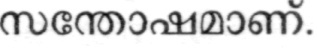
സന്തോഷമാണ്.
